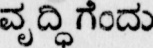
ವೃದ್ಧಿಗೆಂದು
